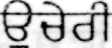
ਉਚੇਰੀ
